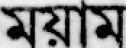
ময়াম
